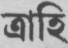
ত্ৰাহি
